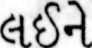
લઈને
